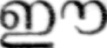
ഈ
